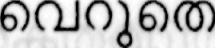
വെറുതെ
